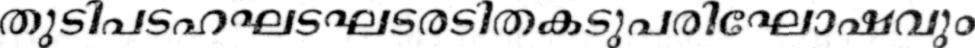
തുടിപടഹഘടഘടരടിതകടുപരിഘോഷവുമ്
